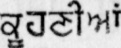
ਕੂਹਣੀਆਂ
